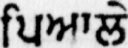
ਪਿਆਲੇ
